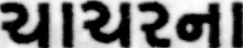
ચાચરના
